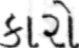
કારો
